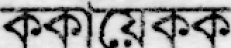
ককায়েকক
